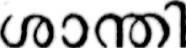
ശാന്തി
